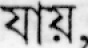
যায়,
